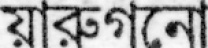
য়ারুগনো
